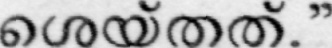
ശെയ്തത്."
